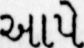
આપે
